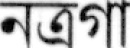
নত্রগা
